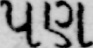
પણ
